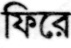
ফিরে
